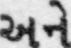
અને
